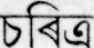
চৰিত্র
